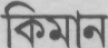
কিমান
